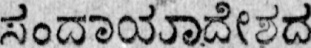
ಸಂದಾಯಾದೇಶದ
